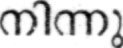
നിന്നു
